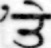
'ਤੇ
